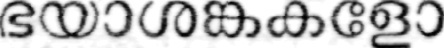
ഭയാശങ്കകളോ
